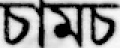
চামচ
